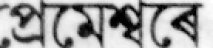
প্রেমেশ্বৰে
